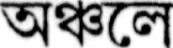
অঞ্চলে
